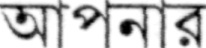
আপনার
